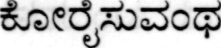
ಕೋರೈಸುವಂಥ
